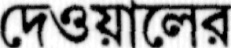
দেওয়ালের
